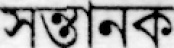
সন্তানক
